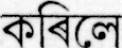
কৰিলে
